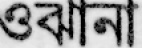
ওঝানা
